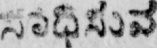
ಸಾಧಿಸುವ
